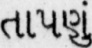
તાપણું
